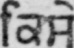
ਕਿਸੇ
